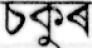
চকুৰ
